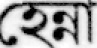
হেন্না
